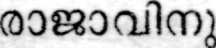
രാജാവിനു
